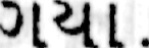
ગયા.
